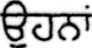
ਉਹਨਾਂ
